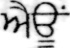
ਐਊਂ
